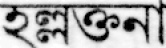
হল্লক্তনা
